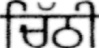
ਚਿੱਠੀ
